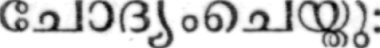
ചോദ്യംചെയ്തു:
